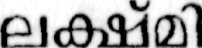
ലക്ഷ്മി
